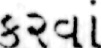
કરવાં
